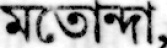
মতোন্দা,
